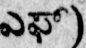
ಎಫ್)
